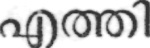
എത്തി
